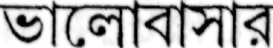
ভালোবাসার
